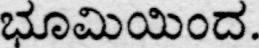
ಭೂಮಿಯಿಂದ.
